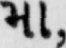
મા,
